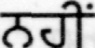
ਨਹੀਂ
